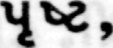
પૃષ્ટ,
